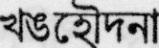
খঙহৌদেনা
